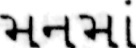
મનમાં
